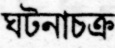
ঘটনাচক্র
